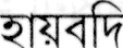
হায়বদি
